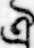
ঐ
